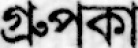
গ্রুপকা
